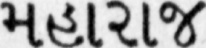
મહારાજ
